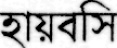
হায়বসি
